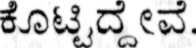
ಕೊಟ್ಟಿದ್ದೇವೆ.
